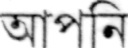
আপনি
